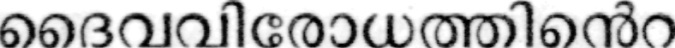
ദൈവവിരോധത്തിന്റെ
